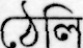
ঠেলি
